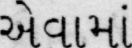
એવામાં
